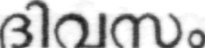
ദിവസം
